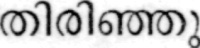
തിരിഞ്ഞു
